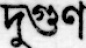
দুগুণ
